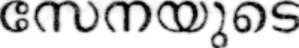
സേനയുടെ
